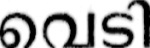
വെടി
